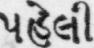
પહેલી
